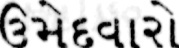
ઉમેદવારો
